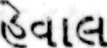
હેવાલ
